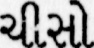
ચીસો
